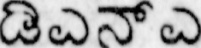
ಡಿಎನ್‌ಎ
